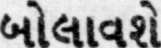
બોલાવશે
